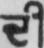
ਦੀ
